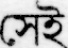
সেই
